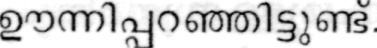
ഊന്നിപ്പറഞ്ഞിട്ടുണ്ട്.
